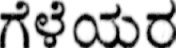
ಗೆಳೆಯರ
